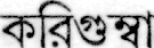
করিগুম্বা
